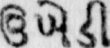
ઉખેડી
